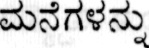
ಮನೆಗಳನ್ನು
